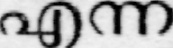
എന്ന
